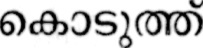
കൊടുത്ത്
